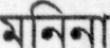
মনিনা
